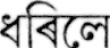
ধৰিলে
